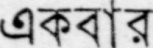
একবার
